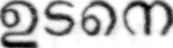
ഉടനെ
